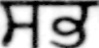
ਸਭ
